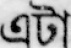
এটা
